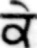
ਕੇ
